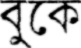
বুকে
